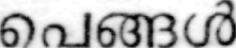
പെങ്ങള്‍
